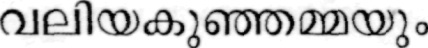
വലിയകുഞ്ഞമ്മയും
